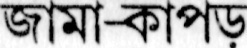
জামা-কাপড়
